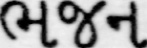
ભજન
